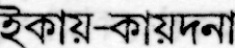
ইকায়-কায়দনা
